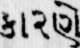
કારણે
